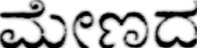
ಮೇಣದ
